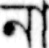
না
